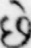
છે
